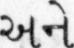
અને
